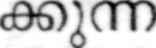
ക്കുന്ന
